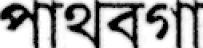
পাথবগা
